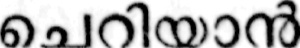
ചെറിയാന്‍
